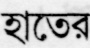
হাতের
